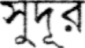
সুদূর
